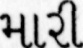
મારી
